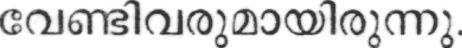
വേണ്ടിവരുമായിരുന്നു.
